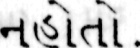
નહોતો.
